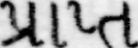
પ્રાપ્ત
